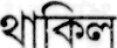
থাকিল
